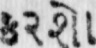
કરશો
